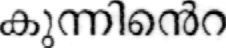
കുന്നിന്റെ
